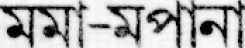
মমা-মপানা
